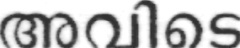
അവിടെ
